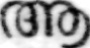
ആ
